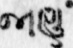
જાણું
